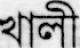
খালী
